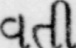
વતી
